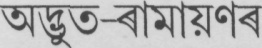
অদ্ভুত-ৰামায়ণৰ
